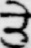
ਤੇ
